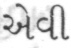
એવી
